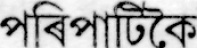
পৰিপাটিকৈ
